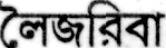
লৈজরিবা
